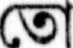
তো
